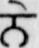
ਨੇ
